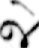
જે
